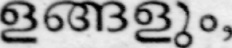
ളങ്ങളും,
